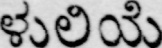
ಳುಲಿಯೆ
